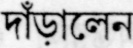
দাঁড়ালেন
